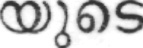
യുടെ
